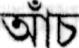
আঁচ
